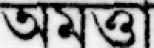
অমত্তা
